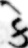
કે
